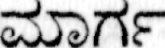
ಮಾರ್ಗ
